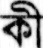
কী
